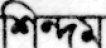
শিন্দম
